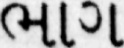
ભાગ
